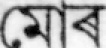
মোৰ
